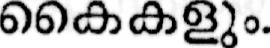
കൈകളും.
